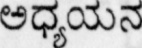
ಅಧ್ಯಯನ
